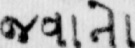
જવાનો
